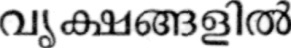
വൃക്ഷങ്ങളില്‍
